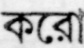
করো
